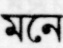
মনে
